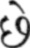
છે.
